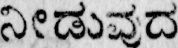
ನೀಡುವುದ
